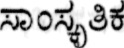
ಸಾಂಸ್ಕೃತಿಕ
